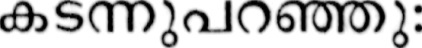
കടന്നുപറഞ്ഞു:
